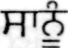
ਸਾਨੂੰ
